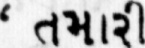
'તમારી
